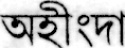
অহীংদা
